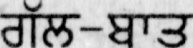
ਗੱਲ-ਬਾਤ
